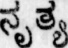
ನೃತ್ಯ
